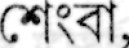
শেংবা,
